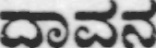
ದಾವನ
